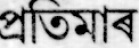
প্রতিমাৰ
